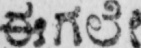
ಈಗಲೇ
